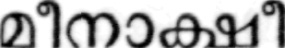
മീനാക്ഷീ
